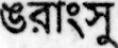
ঙরাংসু
